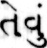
તેવું
